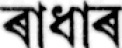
ৰাধাৰ
